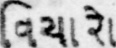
વિચારો
